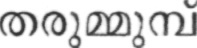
തരുമ്മുമ്പ്
